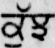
ਕੁੱਝ
